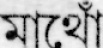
মাথোঁ
